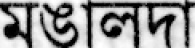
মঙালদা
